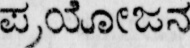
ಪ್ರಯೋಜನ
